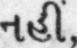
નહીં,
